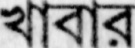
খাবার
